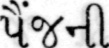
પૈંજની
